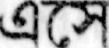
এসে
